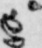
હું
